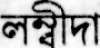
লম্বীদা
